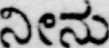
ನೀನು
